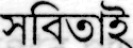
সবিতাই
